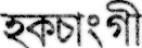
হকচাংগী
